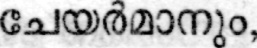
ചേയര്‍മാനും,
